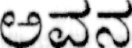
ಅವನ
